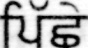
ਪਿੱਛੇ
